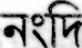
নংদি
